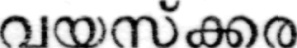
വയസ്ക്കര
